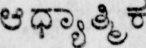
ಆಧ್ಯಾತ್ಮಿಕ
